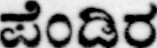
ಪೆಂಡಿರ
